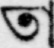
তা
